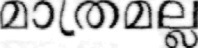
മാത്രമല്ല
